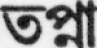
তপ্না
